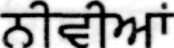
ਨੀਵੀਆਂ
